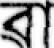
ৱা
